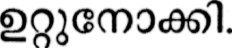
ഉറ്റുനോക്കി.
